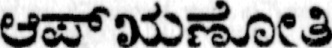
ಆಪ್ಋಣೋತಿ
